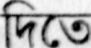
দিতে
